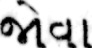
જોવા
